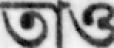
তাও
